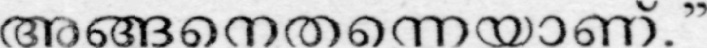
അങ്ങനെതന്നെയാണ്.''
